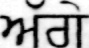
ਅੱਗੇ
